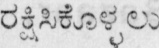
ರಕ್ಷಿಸಿಕೊಳ್ಳಲು
